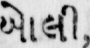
બોલી,
